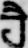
ਹੈ
